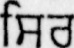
ਸਿਰ
